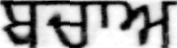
ਬਚਾਅ
